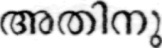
അതിനു
